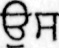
ਉਸ
